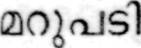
മറുപടി
